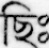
ছিঃ
